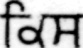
ਕਿਸ
